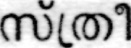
സ്ത്രീ
